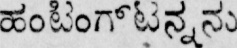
ಹಂಟಿಂಗ್‌ಟನ್ನನು
